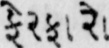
ફેરફારો
